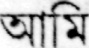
আমি
